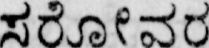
ಸರೋವರ
